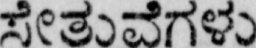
ಸೇತುವೆಗಳು
